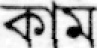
কাম
